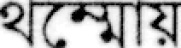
থম্মোয়
